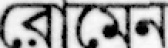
রোমেন
